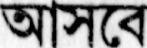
আসবে
